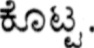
ಕೊಟ್ಟ.
